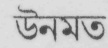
উনমত
